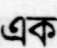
এক
